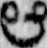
ಆ
